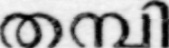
തമ്പി
